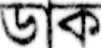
ডাক
